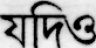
যদিও
